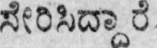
ಸೇರಿಸಿದ್ದಾರೆ.
